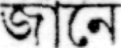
জানে
